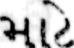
માટે
